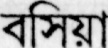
বসিয়া
